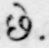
છે.
